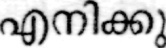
എനിക്കു
